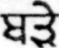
ਬੜੇ
